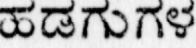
ಹಡಗುಗಳ
